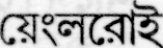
য়েংলরোই
